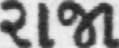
રાજા
